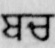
ਬਚ
